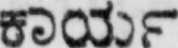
ಕಾರ್ಯ
